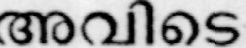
അവിടെ
